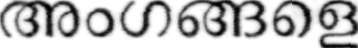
അംഗങ്ങളെ
